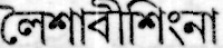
লৈশাবীশিংনা
